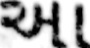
આ
